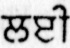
ਲਈ
